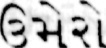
ઉમેરો
